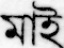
মাই
